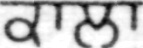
ਕਾਲਾ
